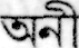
অনী
